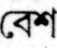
বেশ
